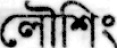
লৌশিং
